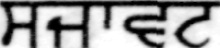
ਸਜਾਵਟ
